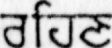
ਰਹਿਣ
